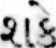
શકે
